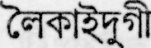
লৈকাইদুগী
